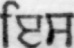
ਇਸ
